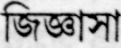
জিজ্ঞাসা
